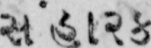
સંહારક
